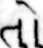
તો
